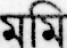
মমি
